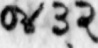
જરૂર
